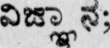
ವಿಜ್ಞಾನ;
